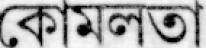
কোমলতা
